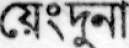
য়েংদুনা
